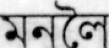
মনলৈ
